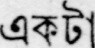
একটা
